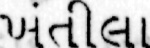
ખંતીલા
